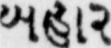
બહાર
